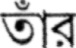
তাঁর
